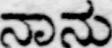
ನಾನು
